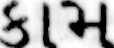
કામ
